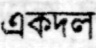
একদল
